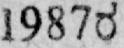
1987ರ
